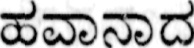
ಹವಾನಾದ
